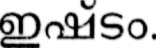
ഇഷ്ടം.
